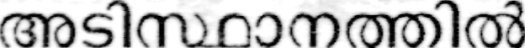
അടിസ്ഥാനത്തില്‍
